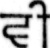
ਵੀ
